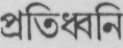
প্রতিধ্বনি
